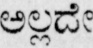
ಅಲ್ಲದೇ
